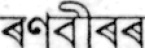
ৰণবীৰৰ
